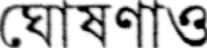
ঘোষণাও
